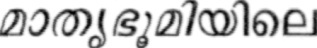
മാതൃഭൂമിയിലെ
